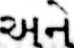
અને
